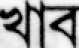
খাব
